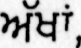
ਅੱਖਾਂ,
